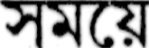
সময়ে
